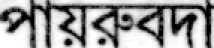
পায়রুবদা
